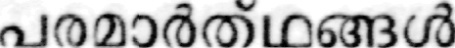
പരമാര്‍ത്ഥങ്ങള്‍
